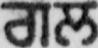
ਗਲ
